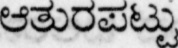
ಆತುರಪಟ್ಟು
